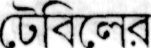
টেবিলের
